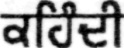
ਕਹਿੰਦੀ
